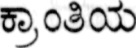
ಕ್ರಾಂತಿಯ
